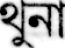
থুনা
